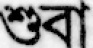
শুবা
